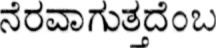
ನೆರವಾಗುತ್ತದೆಂಬ
